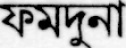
ফমদুনা
